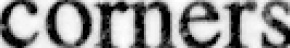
corners
